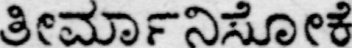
ತೀರ್ಮಾನಿಸೋಕೆ
